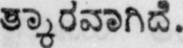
ತ್ಕಾರವಾಗಿದೆ.
